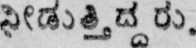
ನೀಡುತ್ತಿದ್ದರು.
